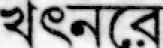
খৎনরে
